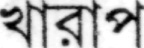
খারাপ
